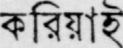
করিয়াই
